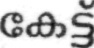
കേട്ട്
